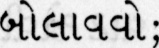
બોલાવવો;
